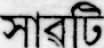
সাৱটি
